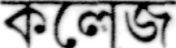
কলেজ
